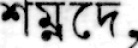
শম্নদে,
